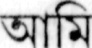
আমি
